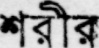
শরীর
